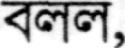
বলল,
